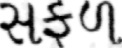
સફળ
